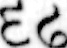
દઢ
